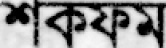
শকফম
